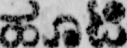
ಹೂಟೆ
